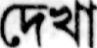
দেখা
